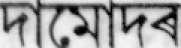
দামোদৰ
